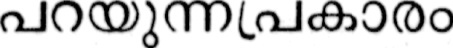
പറയുന്നപ്രകാരം
